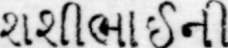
શશીભાઈની
